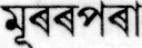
মূৰৰপৰা
